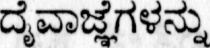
ದೈವಾಜ್ಞೆಗಳನ್ನು
